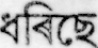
ধৰিছে
